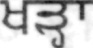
ਖੜ੍ਹਾ
